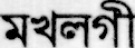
মখলগী
